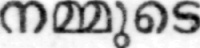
നമ്മുടെ
